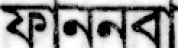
ফাননবা
